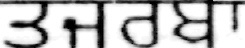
ਤਜਰਬਾ
